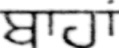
ਬਾਹਾਂ
